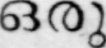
ഒരു
